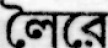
লৈরে
